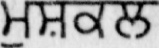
ਮੁਸ਼ਕਲ
